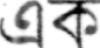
এক
